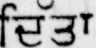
ਦਿੱਤਾ
